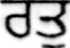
ਰਤੁ
